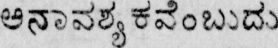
ಅನಾವಶ್ಯಕವೆಂಬುದು
